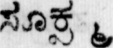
ಸೂಕ್ಷ್ಮ
